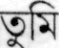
তুমি
